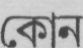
কোন
